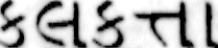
કલકત્તા
